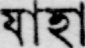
যাহা
